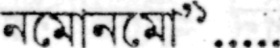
নমোনমো’১.....
